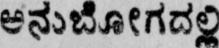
ಅನುಬೋಗದಲ್ಲಿ
